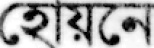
হোয়নে
